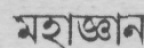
মহাজ্ঞান
